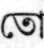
তো
